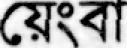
য়েংবা
